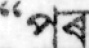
"পৰ
